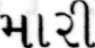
મારી
